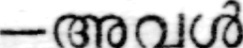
-അവള്‍
